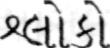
શ્લોકો
